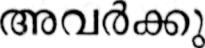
അവര്‍ക്കു
